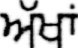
ਅੱਖਾਂ
